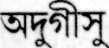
অদুগীসু
